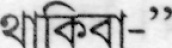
থাকিবা-"
